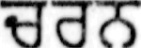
ਚਰਨ
